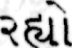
રહ્યો
